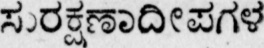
ಸುರಕ್ಷಣಾದೀಪಗಳ
